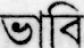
ভাবি
